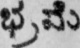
ಭ್ರಮೆ
